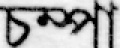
চম্পা
